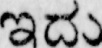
ಇದು
